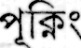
পূক্নিং
